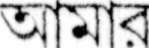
আমার
